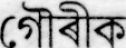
গৌৰীক
